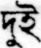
দুই
